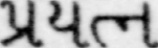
પ્રયત્ન
